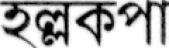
হল্লকপা
